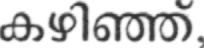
കഴിഞ്ഞ്,
